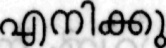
എനിക്കു
